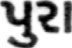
પુરા
